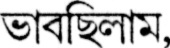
ভাবছিলাম,
